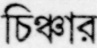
চিঞ্চার
